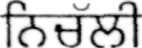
ਨਿਚੱਲੀ
